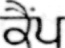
ਕੈਂਪ
